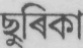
ছুৰিকা
